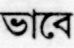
ভাবে
